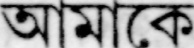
আমাকে
